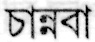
চান্নবা
